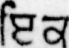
ਇਕ
